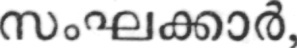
സംഘക്കാര്‍,
